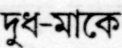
দুধ-মাকে
